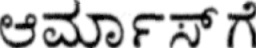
ಆರ್ಮಾಸ್ಗೆ
